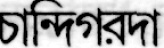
চান্দিগরদা
